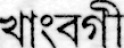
খাংবগী
